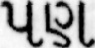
પણ
